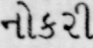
નોકરી
